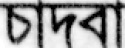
চাদবা
